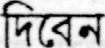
দিবেন
